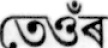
তেওঁৰ
